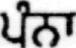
ਪੰਨਾ
